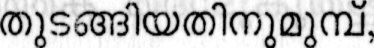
തുടങ്ങിയതിനുമുമ്പ്,
